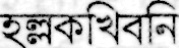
হল্লকখিবনি
